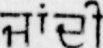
ਜਾਂਦੀ
